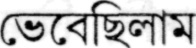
ভেবেছিলাম
